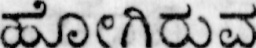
ಹೋಗಿರುವ
